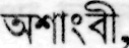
অশাংবী,
